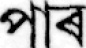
পাৰ
